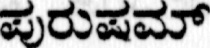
ಪುರುಷಮ್
